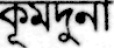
কূমদুনা
